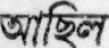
আছিল
